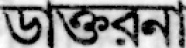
ডাক্তরনা
